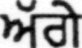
ਅੱਗੇ
